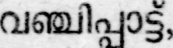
വഞ്ചിപ്പാട്ട്,
